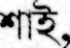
শাই,
